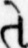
તે
